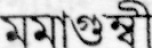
মমাগুম্বী
